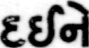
દઈને
